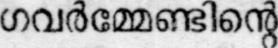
ഗവര്‍മ്മേണ്ടിന്റെ
